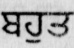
ਬਹੁਤ
